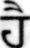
ਹੈ
